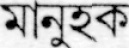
মানুহক
